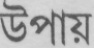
উপায়
